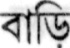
বাড়ি
